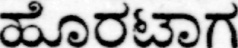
ಹೊರಟಾಗ
